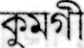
কুমগী
